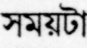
সময়টা
